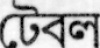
টেবল
